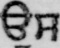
ਉਸ
